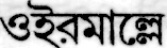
ওইরমাল্লে
